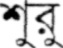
শুরু
